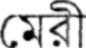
মেরী
